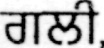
ਗਲੀ,
